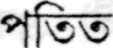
পতিত
